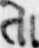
તો
